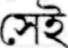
সেই
